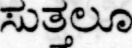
ಸುತ್ತಲೂ
